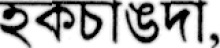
হকচাঙদা,
